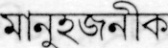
মানুহজনীক
